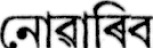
নোৱাৰিব
